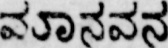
ಮಾನವನ
